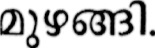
മുഴങ്ങി.
